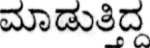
ಮಾಡುತ್ತಿದ್ದ
